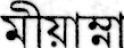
মীয়াম্না
